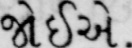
જોઈએ.
